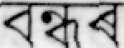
বন্ধৰ
